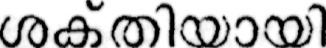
ശക്തിയായി
